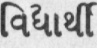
વિધાર્થી
